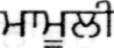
ਮਾਮੂਲੀ
